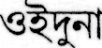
ওইদুনা
